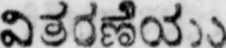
ವಿತರಣೆಯು
